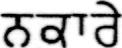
ਨਕਾਰੇ
